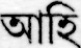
আহি
